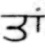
ਤਾਂ
